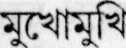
মুখোমুখি
